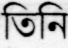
তিনি
